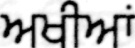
ਅਖੀਆਂ
